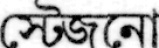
স্টেজনো
